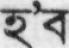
হ'ব
